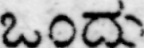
ಒಂದು
